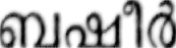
ബഷീര്‍
